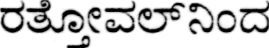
ರತ್ತೋವಲ್ನಿಂದ
